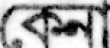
কেনা
